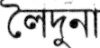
লৈদুনা
